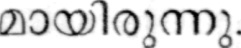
മായിരുന്നു.
